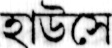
হাউসে
